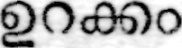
ഉറക്കം
